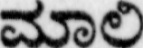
ಮಾಲಿ
